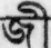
জী
